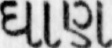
ઘાણ
